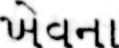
ખેવના
